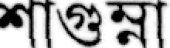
শাগুম্না
